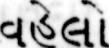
વહેલો
